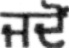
ਜਦੋਂ
